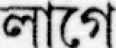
লাগে
